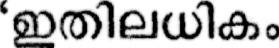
‘ഇതിലധികം
